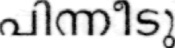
പിന്നീടു
